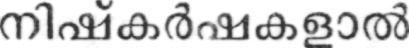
നിഷ്കര്‍ഷകളാല്‍
